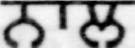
ਨਾਲ
